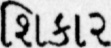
શિકાર
